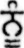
ਨੂੰ
